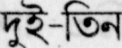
দুই-তিন
